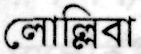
লোল্লিবা
